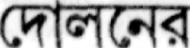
দোলনের
